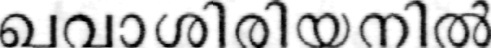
ഖവാശിരിയനില്‍
